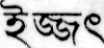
ইজ্জৎ
